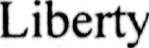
Liberty
